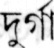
দুর্গা
